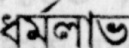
ধর্মলাভ
